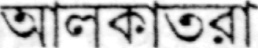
আলকাতরা
